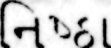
નિષ્ઠા
